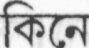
কিনে
